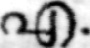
എ.
